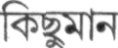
কিছুমান
